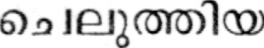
ചെലുത്തിയ
